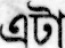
এটা
